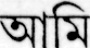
আমি
